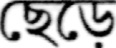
ছেড়ে
